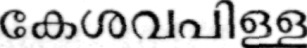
കേശവപിള്ള
